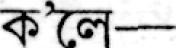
ক'লে-
